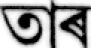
তাৰ
